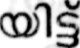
യിട്ട്
